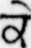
ਕੇ
